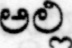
ಅಲ್ಲಿ
